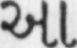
આ
